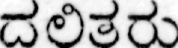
ದಲಿತರು
